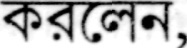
করলেন,
